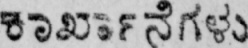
ಕಾರ್ಖಾನೆಗಳು
